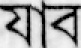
যাব
